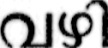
വഴി
